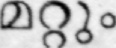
മറ്റും
